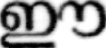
ഈ
